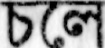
চলে
